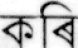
কৰি
